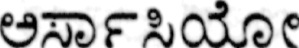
ಅರ್ಸಾಸಿಯೋ
